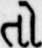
તો
